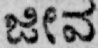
ಜೀವ
